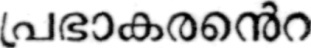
പ്രഭാകരന്റെ
